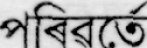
পৰিৱর্তে
